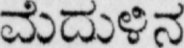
ಮೆದುಳಿನ
